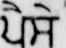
ਪੈਸੇ
